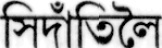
সিদাঁতিলৈ
